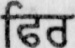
ਫਿਰ
